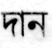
দান
